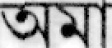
অমা
